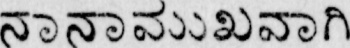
ನಾನಾಮುಖವಾಗಿ
